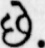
છે.
